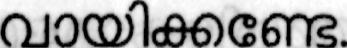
വായിക്കണ്ടേ.
